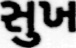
સુખ
